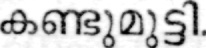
കണ്ടുമുട്ടി.
